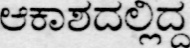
ಆಕಾಶದಲ್ಲಿದ್ದ
